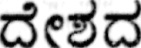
ದೇಶದ
